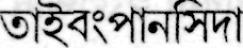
তাইবংপানসিদা
